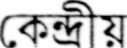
কেন্দ্রীয়
